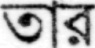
তার
